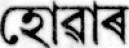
হোৱাৰ
